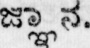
ಜ್ಞಾನ.
